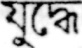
যুদ্ধে
